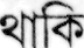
থাকি
